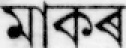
মাকৰ
